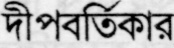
দীপবর্তিকার
